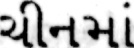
ચીનમાં
